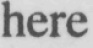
here
